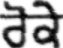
ਰੋਕੇ
